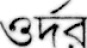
ওর্দর
